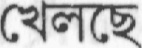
খেলছে
